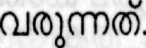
വരുന്നത്.
